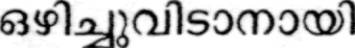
ഒഴിച്ചുവിടാനായി
